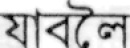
যাবলৈ
